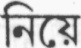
নিয়ে
